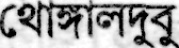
থোঙ্গালদুবু
